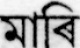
মাৰি
